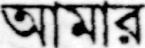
আমার
